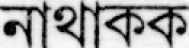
নাথাকক
